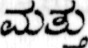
ಮತ್ತು
